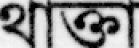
থাক্তা
